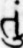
તું
